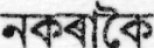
নকৰাকৈ
